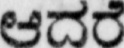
ಆದರೆ
